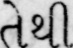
તેથી
